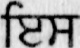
ਇਸ
